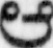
ಆ
